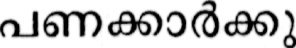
പണക്കാര്‍ക്കു
